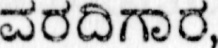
ವರದಿಗಾರ,
